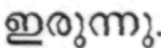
ഇരുന്നു.
